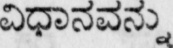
ವಿಧಾನವನ್ನು
